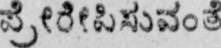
ಪ್ರೇರೇಪಿಸುವಂತೆ
